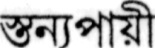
স্তন্যপায়ী
